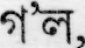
গ'ল,
